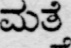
ಮತ್ತೆ
